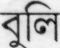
বুলি
